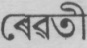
ৰেৱতী
